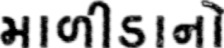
માળીડાનો
